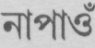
নাপাওঁ
